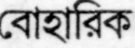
বোহারিক
